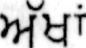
ਅੱਖਾਂ
